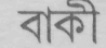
বাকী
